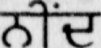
ਨੀਂਦ
